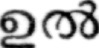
ഉല്‍
